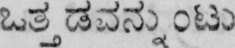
ಒತ್ತಡವನ್ನುಂಟು
